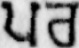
ਪਰ
